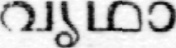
വൃഥാ
